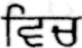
ਵਿਚ
